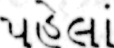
પહેલાં
